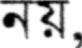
নয়,
